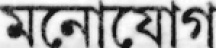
মনোযোগ
